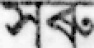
সৰু
